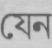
যেন
